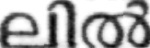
ലില്‍
